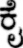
ಕೈ
